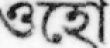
ওহো
